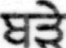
ਬੜੇ
